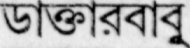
ডাক্তারবাবু
